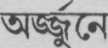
অৰ্জ্জুনে
